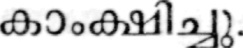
കാംക്ഷിച്ചു.
